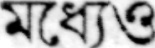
মধ্যেও
